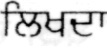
ਲਿਖਦਾ
